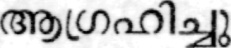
ആഗ്രഹിച്ചു
